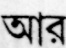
আর
